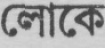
লোকে
